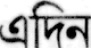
এদিন
